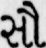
સૌ
